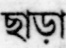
ছাড়া
